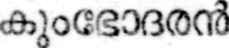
കുംഭോദരന്‍
